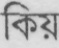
কিয়
